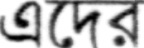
এদের
